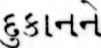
દુકાનને
